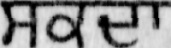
ਸਕਦਾ
